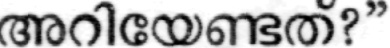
അറിയേണ്ടത്?”
